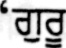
'ਗੁਰੂ
